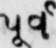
પૂર્વ
